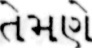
તેમણે
